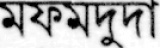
মফমদুদা
